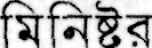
মিনিষ্টর
